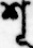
শূ
